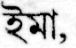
ইমা,
